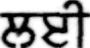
ਲਈ
